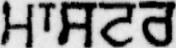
ਮਾਸਟਰ
